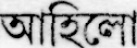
আহিলো
